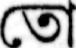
তো
